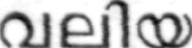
വലിയ
